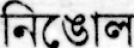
নিঙোল
